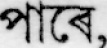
পাৰে,
